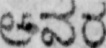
ಅವರ
